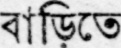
বাড়িতে
